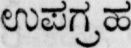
ಉಪಗ್ರಹ
